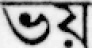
ভয়
